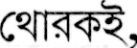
থোরকই,
